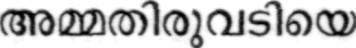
അമ്മതിരുവടിയെ
